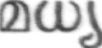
മധ്യ
